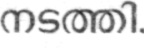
നടത്തി.
